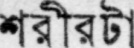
শরীরটা
